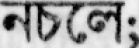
নচলে;
